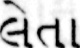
લેતા
